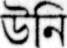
উনি
